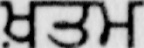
ਖ਼ਤਮ
